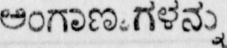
ಅಂಗಾಣುಗಳನ್ನು
